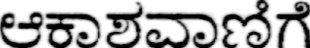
ಆಕಾಶವಾಣಿಗೆ
